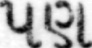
પણ
